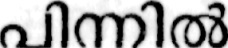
പിന്നില്‍
